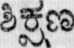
ಶಿಕ್ಷಣ
